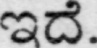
ಇದೆ.
